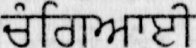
ਚੰਗਿਆਈ
